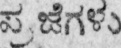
ಪ್ರಜೆಗಳು
